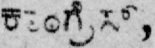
ಕಾಂಗ್ರೆಸ್,
